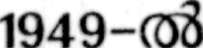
1949-ല്‍
